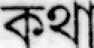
কথা
